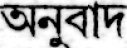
অনুবাদ
